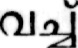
വച്ച്
